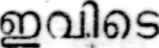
ഇവിടെ
